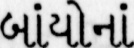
બાંયોનાં
